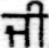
ਜੀ
